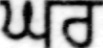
ਘਰ
